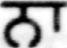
ਨਾ
